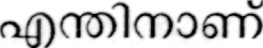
എന്തിനാണ്
